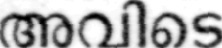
അവിടെ
